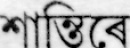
শান্তিৰে
